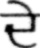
ਦੇ
